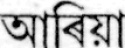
আৰিয়া
